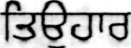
ਤਿਉਹਾਰ
